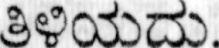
ತಿಳಿಯದು
